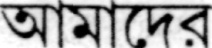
আমাদের
